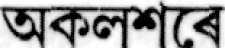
অকলশৰে
